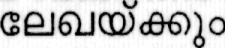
ലേഖയ്ക്കും
